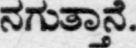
ನಗುತ್ತಾನೆ.
